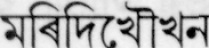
মৰিদিখৌখন
